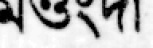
মওংদা
